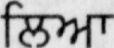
ਲਿਆ
